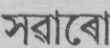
সৱাৰো
